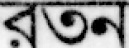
রতন
